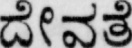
ದೇವತೆ
